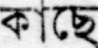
কাছে
